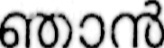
ഞാന്‍
